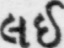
લઈ
